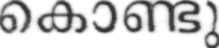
കൊണ്ടു
